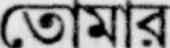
তোমার
